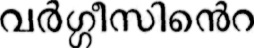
വര്‍ഗ്ഗീസിന്റെ
